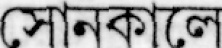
সোনকালে
